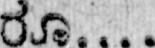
ರೂ.....
